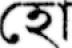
হো
